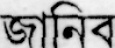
জানিব
